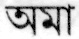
অমা
